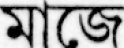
মাজে
